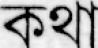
কথা
